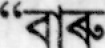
"বাৰু
